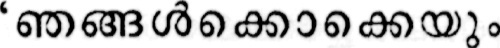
‘ഞങ്ങള്‍ക്കൊക്കെയും
